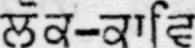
ਲੋਕ-ਕਾਵਿ
